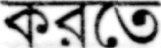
করতে
